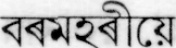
বৰমহৰীয়ে
